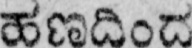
ಹಣದಿಂದ
